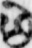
છે
